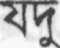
যদু
